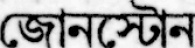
জোনস্টোন
